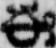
ಈ
